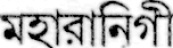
মহারানিগী
